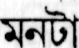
মনটা
